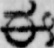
ಈ
